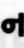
ન
